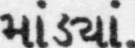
માંડ્યાં.
